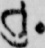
તુ.
